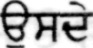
ਉਸਦੇ
